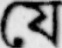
যে
